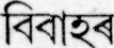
বিবাহৰ
